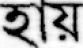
হায়
